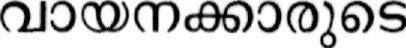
വായനക്കാരുടെ
